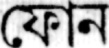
ফোন
